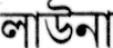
লাউনা
